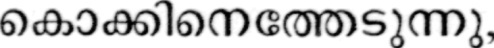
കൊക്കിനെത്തേടുന്നു,
